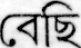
বেছি
